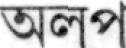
অলপ
